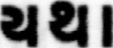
યથા
